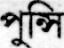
পুন্সি
